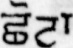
ਛੋਟਾ
